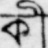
কী
